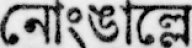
নোংঙাল্লে
